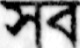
সব
